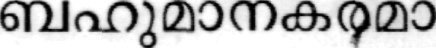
ബഹുമാനകരമാ
